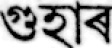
গুহাৰ
